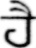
ਹੈ
